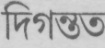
দিগন্তত
